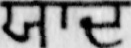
ਯਾਦ
